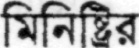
মিনিষ্ট্রির
